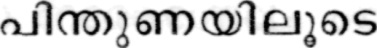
പിന്തുണയിലൂടെ
